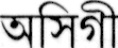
অসিগী
